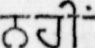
ਨਹੀਂ
